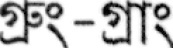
গ্রুং-গ্রাং
